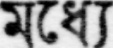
মধ্যে
